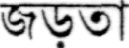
জড়তা
